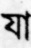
যা
